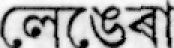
লেঙেৰা
